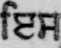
ਇਸ
